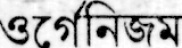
ওর্গেনিজম
